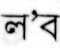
ল'ব
